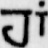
ਹਾਂ
